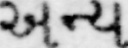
અન્ય
